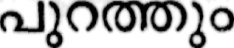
പുറത്തും
